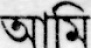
আমি
